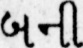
બની
